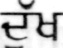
ਦੁੱਖ
